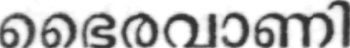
ഭൈരവാണി
